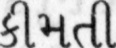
કીમતી
